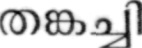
തങ്കച്ചി
